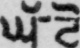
ਘੱਟੋ
